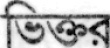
ভিক্তর
